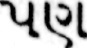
પણ
